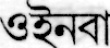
ওইনবা
